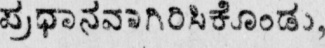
ಪ್ರಧಾನವಾಗಿರಿಸಿಕೊಂಡು,
